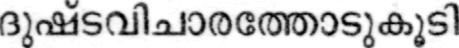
ദുഷ്ടവിചാരത്തോടുകൂടി
